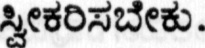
ಸ್ವೀಕರಿಸಬೇಕು.
